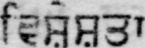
ਵਿਸ਼ੇਸ਼ਤਾ
